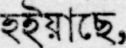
হইয়াছে,
